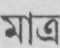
মাত্ৰ
